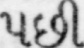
પછી
